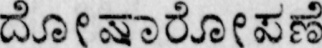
ದೋಷಾರೋಪಣೆ
